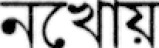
নখোয়
